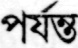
পর্যন্ত
